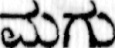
ಮಗು
